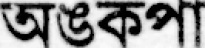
অঙকপা
